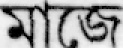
মাজে
